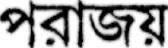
পরাজয়
